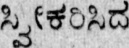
ಸ್ವೀಕರಿಸಿದ
